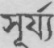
সূৰ্য্য
